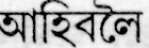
আহিবলৈ
